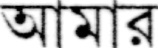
আমার
